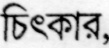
চিত্কার,
